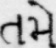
તમે
